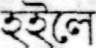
হইলে
